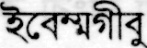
ইবেম্মগীবু
